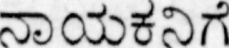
ನಾಯಕನಿಗೆ
